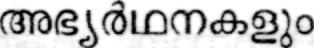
അഭ്യര്‍ഥനകളും
